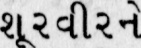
શૂરવીરને
